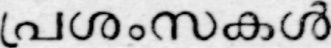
പ്രശംസകള്‍
